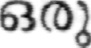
ഒരു
